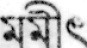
মমীৎ
